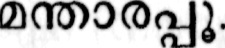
മന്താരപ്പൂ.
